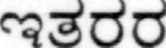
ಇತರರ
